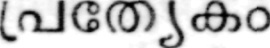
പ്രത്യേകം
